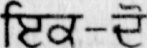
ਇਕ-ਦੋ
